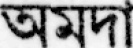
অমদা
